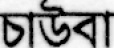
চাউবা
